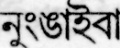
নুংঙাইবা
